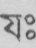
যঃ
